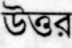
উত্তর
